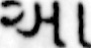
આ
